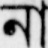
না
